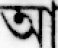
আ
